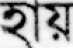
হায়
